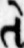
તે
